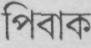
পিবাক
